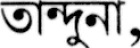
তান্দুনা,
